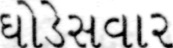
ઘોડેસવાર
